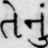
તેનું
